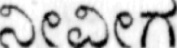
ನೀವೀಗ
